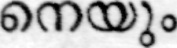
നെയും
